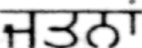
ਜਤਨਾਂ
